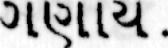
ગણાય.
